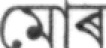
মোৰ
